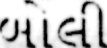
બોલી
